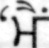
'ਮੈਂ
